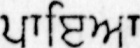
ਪਾਇਆ
